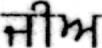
ਜੀਅ
